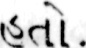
હતો.
